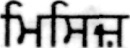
ਮਿਸਿਜ਼
